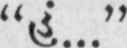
"હં...."
